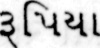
રૂપિયા
